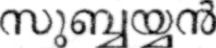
സുബ്ബയ്യന്‍
